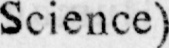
Science)
